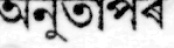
অনুতাপৰ
